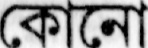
কোনো
